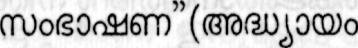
സംഭാഷണ'(അദ്ധ്യായം
